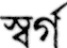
স্বর্গ
